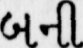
બની
